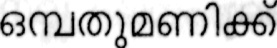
ഒമ്പതുമണിക്ക്
